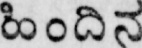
ಹಿಂದಿನ
